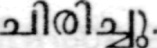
ചിരിച്ചു.
